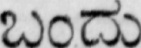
ಬಂದು
